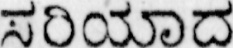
ಸರಿಯಾದ
